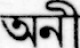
অনী
